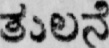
ತುಲನೆ
